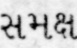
સમક્ષ
